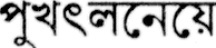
পুখৎলনেয়ে
